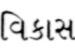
વિકાસ
